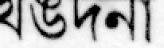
খঙদনা
